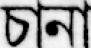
চানা
